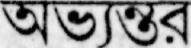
অভ্যন্তর
